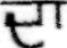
ਦਾ
